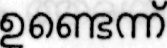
ഉണ്ടെന്ന്
